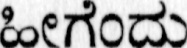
ಹೀಗೆಂದು
